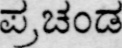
ಪ್ರಚಂಡ
